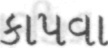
કાપવા
